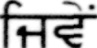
ਜਿਵੇਂ
